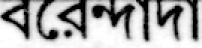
বরেন্দাদা
